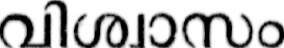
വിശ്വാസം
